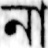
না
